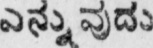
ಎನ್ನುವುದು
